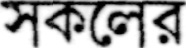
সকলের
